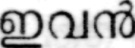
ഇവന്‍
